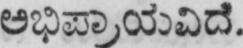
ಅಭಿಪ್ರಾಯವಿದೆ.
